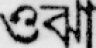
ওঝা
